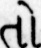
તો
